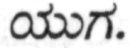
ಯುಗ.
